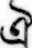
ঐ
